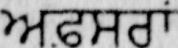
ਅਫ਼ਸਰਾਂ
